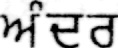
ਅੰਦਰ
